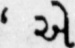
'એ
